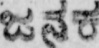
ಜನಕ
